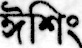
ঈশিং
